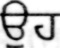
ਉਹ
